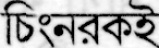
চিংনরকই
